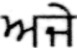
ਅਜੇ
